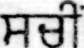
ਸਚੀਂ
